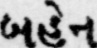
બહેન
